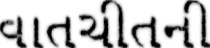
વાતચીતની
